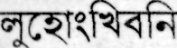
লুহোংখিবনি
